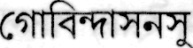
গোবিন্দাসনসু
